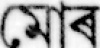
মোৰ
